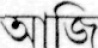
আজি
